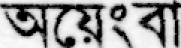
অয়েংবা
